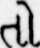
તો
